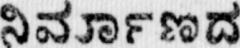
ನಿರ್ಮಾಣದ
